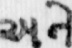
અને
